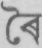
ৰৈ
